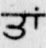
ਤਾਂ
